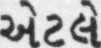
એટલે
